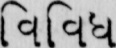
વિવિધ
